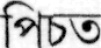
পিচত
